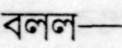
বলল–
